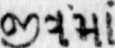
જીવમાં
